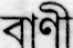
বাণী
